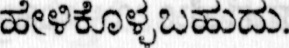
ಹೇಳಿಕೊಳ್ಳಬಹುದು.
